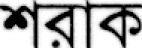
শরাক
